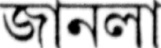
জানলা
